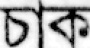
চাক
